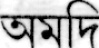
অমদি
